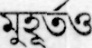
মুহূর্তও
